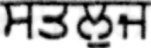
ਸਤਲੁਜ
